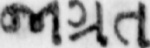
જાગ્રત
